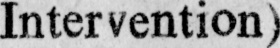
Intervention)
